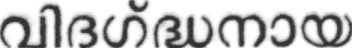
വിദഗ്ദ്ധനായ
